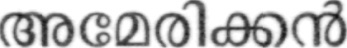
അമേരിക്കന്‍
